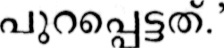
പുറപ്പെട്ടത്.’
